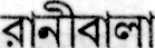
রানীবালা
